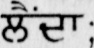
ਲੈਂਦਾ;
